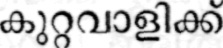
കുറ്റവാളിക്ക്
